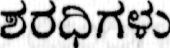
ಶರಧಿಗಳು
